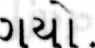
ગયો.
